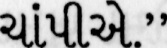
ચાંપીએ."
